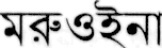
মরুওইনা
